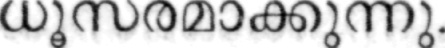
ധൂസരമാക്കുന്നു.
